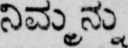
ನಿಮ್ಮನ್ನು
